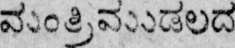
ಮಂತ್ರಿಮಂಡಲದ
